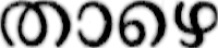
താഴെ
